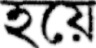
হয়ে
